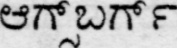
ಆಗ್ಸ್‌ಬರ್ಗ್
